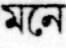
মনে
